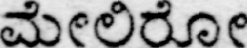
ಮೇಲಿರೋ
